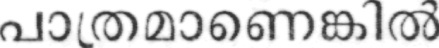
പാത്രമാണെങ്കില്‍
